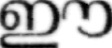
ഈ
